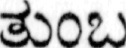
ತುಂಬ
